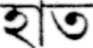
হাত
